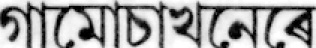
গামোচাখনেৰে
